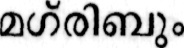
മഗ്രിബും
